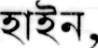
হাইন,
